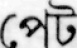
পেট
